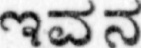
ಇವನ
